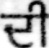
ਦੀ
